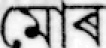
মোৰ
